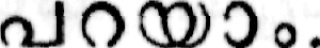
പറയാം.
